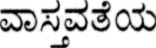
ವಾಸ್ತವತೆಯ
